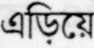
এড়িয়ে
